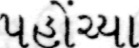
પહોંચ્યા
